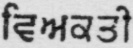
ਵਿਅਕਤੀ
